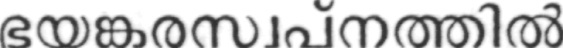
ഭയങ്കരസ്വപ്നത്തില്‍
